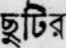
ছুটির
